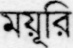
ময়ূরি
